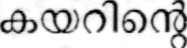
കയറിന്റെ
